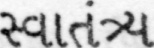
સ્વાતંત્ર્ય
